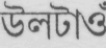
উলটাওঁ
